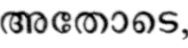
അതോടെ,
